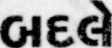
બદલે
